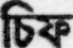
চিফ
